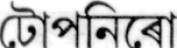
টোপনিৰো
